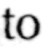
to
